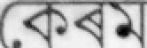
কেৰম
